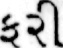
ફરી
